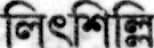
লিৎশিল্লি
